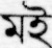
মই
